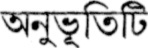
অনুভূতিটি
